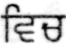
ਵਿਚ
